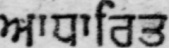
ਆਧਾਰਿਤ
